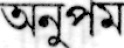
অনুপম
